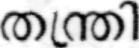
തന്ത്രി
